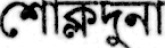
শোক্লদুনা
